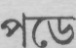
পড়ে
